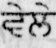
ਵੇਲੇ
